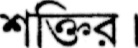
শক্তির।
